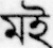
মই
